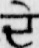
ਦੇ
